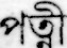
পত্নী
